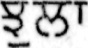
ਝੁਲਾ
